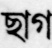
ছাগ
